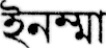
ইনম্মা
